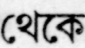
থেকে
